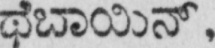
ಥೆಬಾಯಿನ್,
